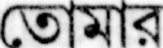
তোমার
